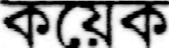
কয়েক
